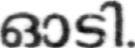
ഓടി.
